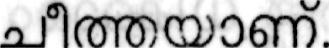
ചീത്തയാണ്.
